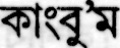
কাংবু’ম
